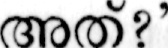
അത്?’
